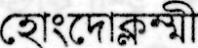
হোংদোক্লম্মী
